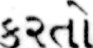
કરતો
